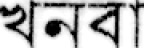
খনবা
